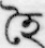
হৈ
